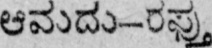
ಆಮದು-ರಫ್ತು
